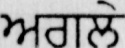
ਅਗਲੇ
